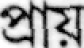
প্রায়
